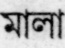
মালা
